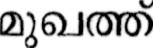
മുഖത്ത്
